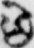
છે
